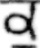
ਕੁ
